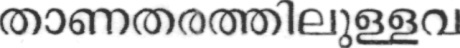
താണതരത്തിലുള്ളവ
